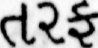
તરફ
